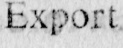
Export
